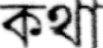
কথা
